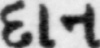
દાન
